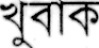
খুবাক
